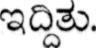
ಇದ್ದಿತು.
